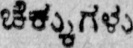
ಚೆಕ್ಕುಗಳು
